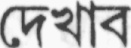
দেখাব
